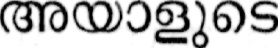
അയാളുടെ
